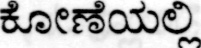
ಕೋಣೆಯಲ್ಲಿ
